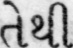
તેથી
